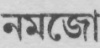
নমজো
